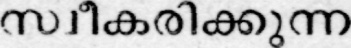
സ്വീകരിക്കുന്ന
